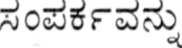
ಸಂಪರ್ಕವನ್ನು
